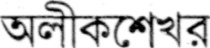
অলীকশেখর
